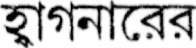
হ্বাগনারের
